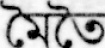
মৈতৈ
